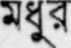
মধুর
